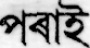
পৰাই
